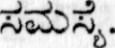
ಸಮಸ್ಯೆ.
